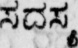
ಸದಸ್ಯ
